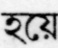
হয়ে
